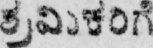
ಶ್ರಮಿಕರಿಗೆ
